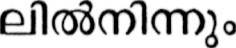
ലില്‍നിന്നും
